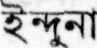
ইন্দুনা
